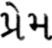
પ્રેમ
